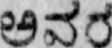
ಅವರ
